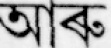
আৰু
